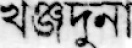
খঞ্জদুনা
